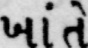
ખાંતે
